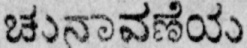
ಚುನಾವಣೆಯ
